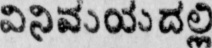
ವಿನಿಮಯದಲ್ಲಿ
